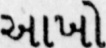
આખો
